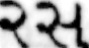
રસ
